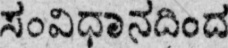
ಸಂವಿಧಾನದಿಂದ
